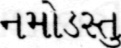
નમોડસ્તુ
